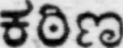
ಕಠಿಣ
